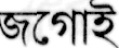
জগোই
